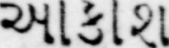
આકાશ
